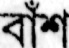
বাঁশ
